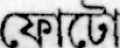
ফোটো
